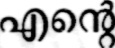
എന്റെ
